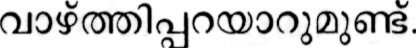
വാഴ്ത്തിപ്പറയാറുമുണ്ട്.
